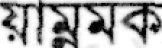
য়াম্নমক
